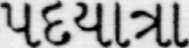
પદયાત્રા
